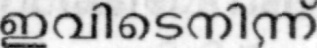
ഇവിടെനിന്ന്
